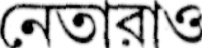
নেতারাও
